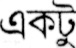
একটু
